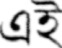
এই
